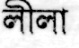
লীলা
